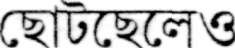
ছোটছেলেও
